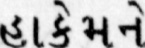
હાકેમને
